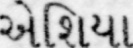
એશિયા
